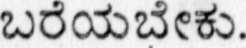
ಬರೆಯಬೇಕು.
